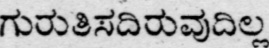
ಗುರುತಿಸದಿರುವುದಿಲ್ಲ
